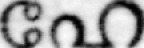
ഹേ
